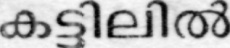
കട്ടിലില്‍
